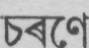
চৰণে
